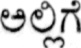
ಅಲ್ಲಿಗೆ
